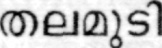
തലമുടി
